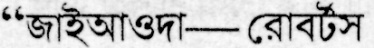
“জাইআওদা-রোবর্টস
